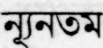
ন্যূনতম
